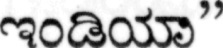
ಇಂಡಿಯಾ’’
